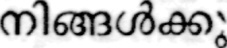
നിങ്ങള്‍ക്കു
